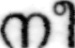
നീ
